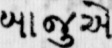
બાજુએ
